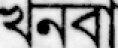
খনবা
